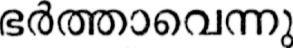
ഭര്‍ത്താവെന്നു
